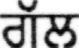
ਗੱਲ
